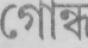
গোন্ধ
